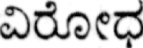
ವಿರೋಧ
